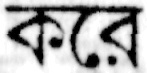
করে
